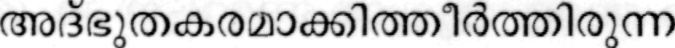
അദ്ഭുതകരമാക്കിത്തീര്‍ത്തരുന്ന
